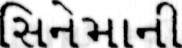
સિનેમાની
